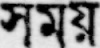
সময়
